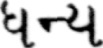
ધન્ય
